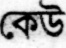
কেউ
